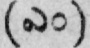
(ಎಂ)
